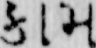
કામ
